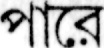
পারে
